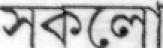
সকলো
